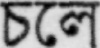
চলে
